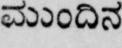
ಮುಂದಿನ
